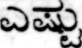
ಎಷ್ಟು
